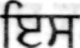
ਇਸ
